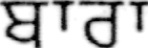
ਬਾਰਾਂ
